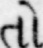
તો
